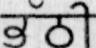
ਭੱਠੀ
